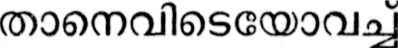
താനെവിടെയോവച്ച്
